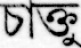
চাক্তু
